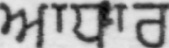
ਆਧਾਰ
